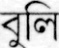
বুলি
